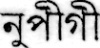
নুপীগী
